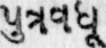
પુત્રવધૂ'
